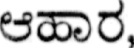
ಆಹಾರ,
